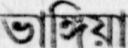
ভাঙ্গিয়া
